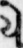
યે
